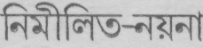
নিমীলিত-নয়না
